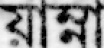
য়াম্না
